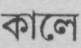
কালে
